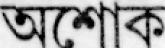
অশোক
